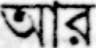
আর
